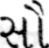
સૌ
